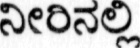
ನೀರಿನಲ್ಲಿ
